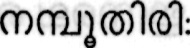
നമ്പൂതിരി:
